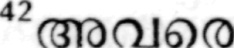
42അവരെ
